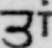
ਤਾਂ
